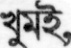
খুমই,
